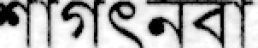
শাগৎনবা
